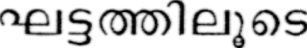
ഘട്ടത്തിലൂടെ
